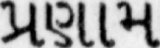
પ્રણામ
